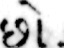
છો.
